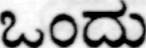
ಒಂದು
